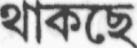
থাকছে
